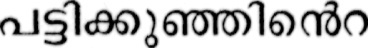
പട്ടിക്കുഞ്ഞിന്റെ
